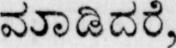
ಮಾಡಿದರೆ,
